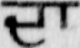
ਦਾ
